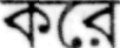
করে
